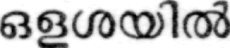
ഒളശയില്‍
